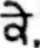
ਕੇ,
